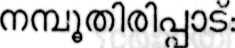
നമ്പൂതിരിപ്പാട്:
